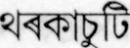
থৰকাচুটি
